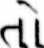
તો
